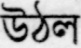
উঠল
